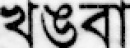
খঙবা
